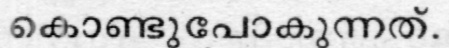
കൊണ്ടുപോകുന്നത്.
